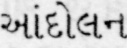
આંદોલન
